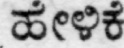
ಹೇಳಿಕೆ
